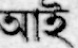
আই
